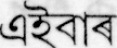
এইবাৰ
